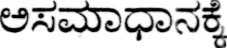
ಅಸಮಾಧಾನಕ್ಕೆ
